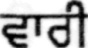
ਵਾਰੀ
